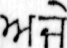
ਅਜੇ
